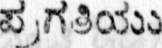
ಪ್ರಗತಿಯು
